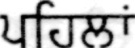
ਪਹਿਲਾਂ
